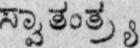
ಸ್ವಾತಂತ್ರ್ಯ
